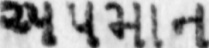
અપમાન
